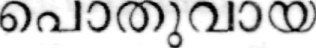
പൊതുവായ
